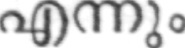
എന്നും
